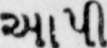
આપી
